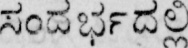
ಸಂದರ್ಭದಲ್ಲಿ
